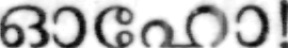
ഓഹോ!
